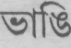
ভাঙি
